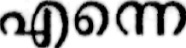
എന്നെ
